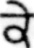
ਕੇ
